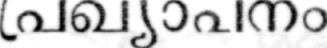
പ്രഖ്യാപനം
